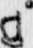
તું
